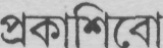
প্ৰকাশিবো
